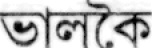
ভালকৈ
